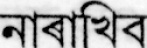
নাৰাখিব
